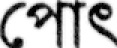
পোৎ
